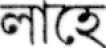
লাহে
